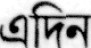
এদিন
